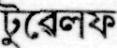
টুৱেলফ
